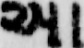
આ
